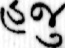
હજુ
